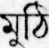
মুঠি
